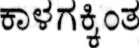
ಕಾಳಗಕ್ಕಿಂತ
